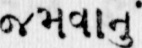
જમવાનું
